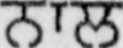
ਨਾਲ
